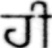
ਹੀ
